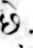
છે.
